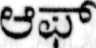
ಆಫ್
